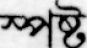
স্পষ্ট
